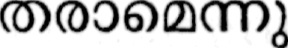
തരാമെന്നു
